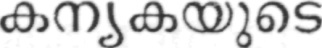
കന്യകയുടെ
